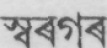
স্বৰগৰ
